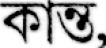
কান্ত,
